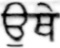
ਉਥੇ
